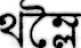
থম্লৈ
